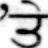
'ਤੇ
